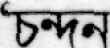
'চন্দন
